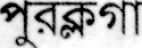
পুরক্লগা
